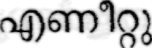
എണീറ്റു
